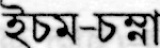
ইচম-চম্না
